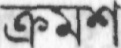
ক্রমশ
